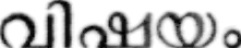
വിഷയം
